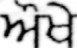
ਔਖੇ
